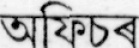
অফিচৰ
